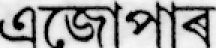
এজোপাৰ
